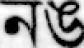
নঙ
